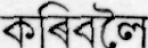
কৰিবলৈ
